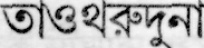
তাওথরুদুনা
